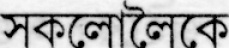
সকলোলৈকে
